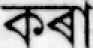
কৰা
